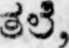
ತಲೆ,
